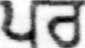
ਪਰ
